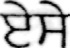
ਏਸੇ
